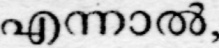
എന്നാല്‍,
